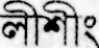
লীশীং
